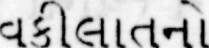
વકીલાતનો
